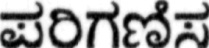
ಪರಿಗಣಿಸ
